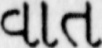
વાત
